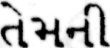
તેમની
